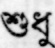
শুধু
